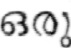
ഒരു
